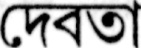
দেবতা
